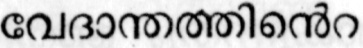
വേദാന്തത്തിന്റെ
